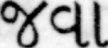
જવા
